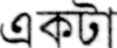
একটা
